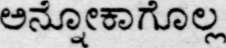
ಅನ್ನೋಕಾಗೊಲ್ಲ
